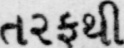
તરફથી
